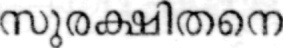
സുരക്ഷിതനെ
